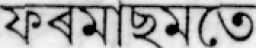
ফৰমাছমতে
